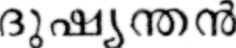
ദുഷ്യന്തന്‍
